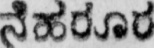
ನೆಹರೂರ
